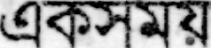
একসময়
